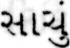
સાચું
